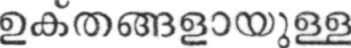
ഉക്തങ്ങളായുള്ള
